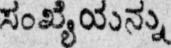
ಸಂಖ್ಯೆಯನ್ನು
